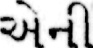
એની
